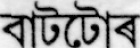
বাটটোৰ
